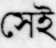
সেই
